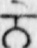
ਨੇ
